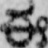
ಈ
